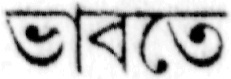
ভাবতে
